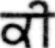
ਕੀ
